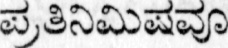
ಪ್ರತಿನಿಮಿಷವೂ
